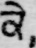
ਕੇ,
